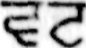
ਵਟ
